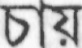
চায়
